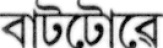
বাটটোৱে
